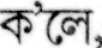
ক'লে,
